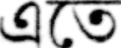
এতে
